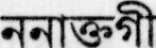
ননাক্তগী
